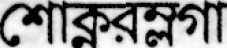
শোক্নরম্লগা
